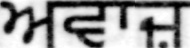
ਅਵਾਜ਼
